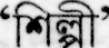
‘শিল্লী’
